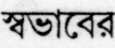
স্বভাবের
